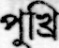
পুখ্রি
